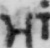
ਮਾਂ
